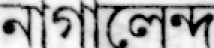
নাগালেন্দ
